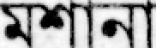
মশানা
